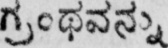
ಗ್ರಂಥವನ್ನು
